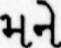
મને
